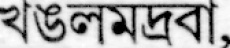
খঙলমদ্রবা,
